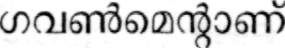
ഗവണ്‍മെന്റാണ്
